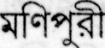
মণিপুরী
